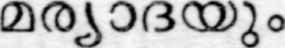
മര്യാദയും
